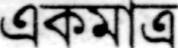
একমাত্র
